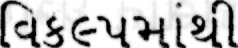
વિકલ્પમાંથી
